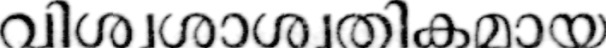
വിശ്വശാശ്വതികമായ
